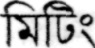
মিটিং
